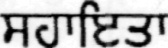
ਸਹਾਇਤਾ
